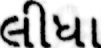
લીધા
